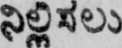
ನಿಲ್ಲಿಸಲು
